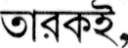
তারকই,
